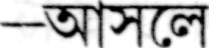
-আসলে
